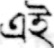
এই
